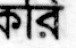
করি
